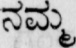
ನಮ್ಮ
